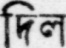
দিল
